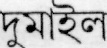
দুমাইল
